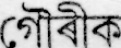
গৌৰীক
